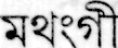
মথংগী
